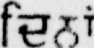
ਦਿਨਾਂ
